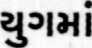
યુગમાં
